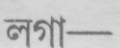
লগা-
